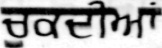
ਚੁਕਦੀਆਂ
